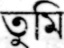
তুমি
